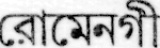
রোমেনগী
